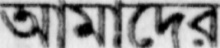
আমাদের
